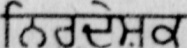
ਨਿਰਦੇਸ਼ਕ
